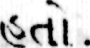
હતો.
